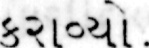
કરાવ્યો.
